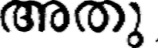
അതു.
